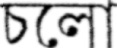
চলো
